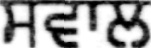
ਸਵਾਲ
